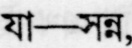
যা–সন্ন,
